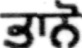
ਭਾਨੋ
